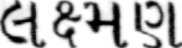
લક્ષ્મણ
